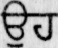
ਉਹ
